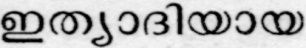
ഇത്യാദിയായ
